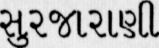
સુરજારાણી
